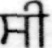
ਸੀ
